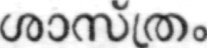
ശാസ്ത്രം
